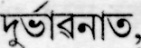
দুর্ভাৱনাত,
